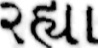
રહ્યા
